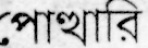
পোত্থারি
